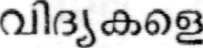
വിദ്യകളെ
